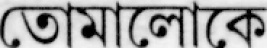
তোমালোকে
